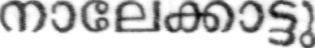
നാലേക്കാട്ടു
